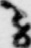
કે
